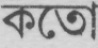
কতো
